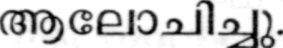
ആലോചിച്ചു.
